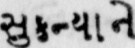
સુકન્યાને
